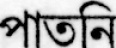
পাতনি
